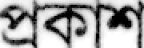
প্রকাশ
